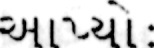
આપ્યોઃ
